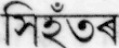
সিহঁতৰ
